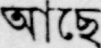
আছে
